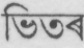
ভিতৰ
